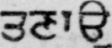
ਤਣਾਉ
